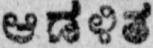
ಆಡಳಿತ
